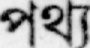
পথ্য
